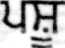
ਪਸ਼ੂ
